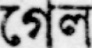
গেল
